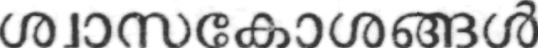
ശ്വാസകോശങ്ങള്‍
